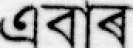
এবাৰ
